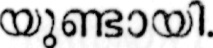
യുണ്ടായി.
